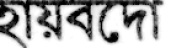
হায়বদো
